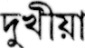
দুখীয়া
